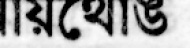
মায়থোঙ
